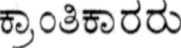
ಕ್ರಾಂತಿಕಾರರು
